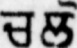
ਚਲੋ
